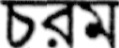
চরম
